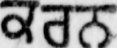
ਕਰਨ
